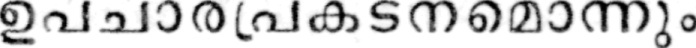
ഉപചാരപ്രകടനമൊന്നും
